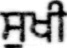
ਸੁਖੀ
